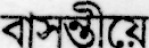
বাসন্তীয়ে
